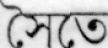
সৈতে
